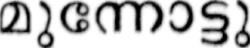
മുന്നോട്ടു
